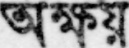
অক্ষয়
